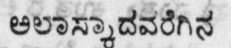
ಅಲಾಸ್ಕಾದವರೆಗಿನ
